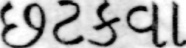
છટકવા
